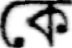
কে
